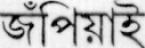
জঁপিয়াই
